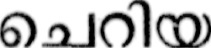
ചെറിയ
